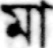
মা
